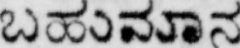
ಬಹುಮಾನ
